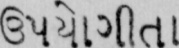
ઉપયોગીતા
